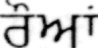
ਰੌਆਂ
